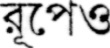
রূপেও
